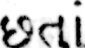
છતાં
